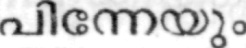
പിന്നേയും
